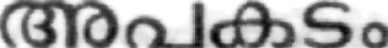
അപകടം
